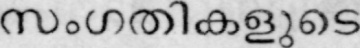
സംഗതികളുടെ
